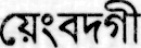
য়েংবদগী
